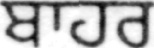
ਬਾਹਰ
